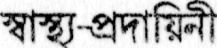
স্বাস্থ্য-প্রদায়িনী
